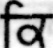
ਕਿ
